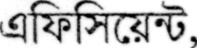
এফিসিয়েন্ট,
